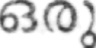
ഒരു
